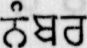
ਨੰਬਰ
